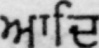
ਆਦਿ
